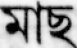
মাছ
